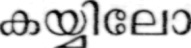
കയ്യിലോ
